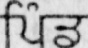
ਪਿੰਡ
